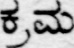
ಕ್ರಮ
